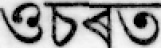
ওচৰত
